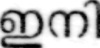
ഇനി
